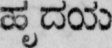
ಹೃದಯ
